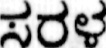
ಸರಳ
